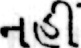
નહીં
